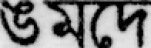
ঙমদে
